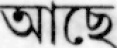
আছে
